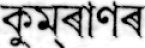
কুম্‌ৰাণৰ
